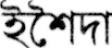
ইশৈদা
